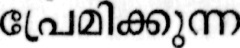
പ്രേമിക്കുന്ന
